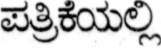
ಪತ್ರಿಕೆಯಲ್ಲಿ
